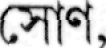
সোণ,
